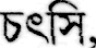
চৎসি,
